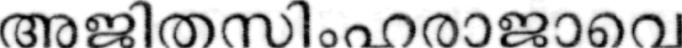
അജിതസിംഹരാജാവെ
